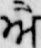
ਐ
